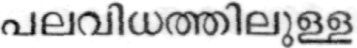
പലവിധത്തിലുള്ള
